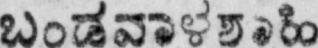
ಬಂಡವಾಳಶಾಹಿ
